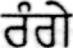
ਰੰਗੇ
